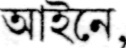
আইনে,
